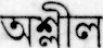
অশ্লীল
